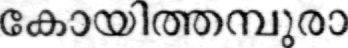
കോയിത്തമ്പുരാ
